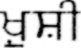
ਖ਼ੁਸ਼ੀ
